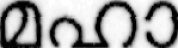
മഹാ
